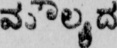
ಮೌಲ್ಯದ
